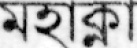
মহাক্না
